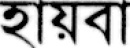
হায়বা
